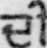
ਦੀ
